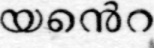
യന്റെ
